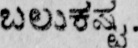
ಬಲುಕಷ್ಟ.
